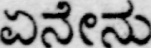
ಏನೇನು
